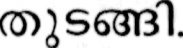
തുടങ്ങി.
